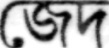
জেদ
